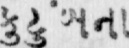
કુટુંબના
